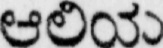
ಆಲಿಯ
